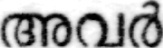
അവര്‍
